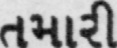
તમારી
